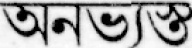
অনভ্যস্ত
